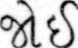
જોઈ
